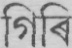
গিৰি
